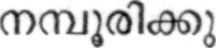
നമ്പൂരിക്കു
